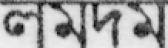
লমদম
